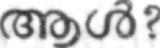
ആള്‍?
